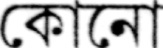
কোনো
